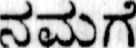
ನಮಗೆ
